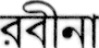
রবীনা
